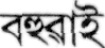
বহুৱাই
